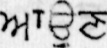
ਆਉਣ
